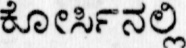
ಕೋರ್ಸಿನಲ್ಲಿ
